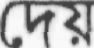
দেয়
